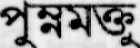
পুম্নমক্তু
